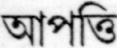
আপত্তি
